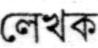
লেখক
